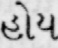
હોય
